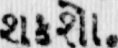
શકશો.
